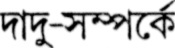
দাদু-সম্পর্কে
